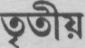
তৃতীয়
